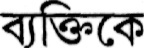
ব্যক্তিকে
